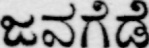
ಜವಗೆಡೆ
